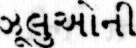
ઝૂલુઓની
